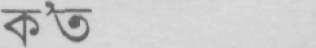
ক'ত
